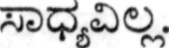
ಸಾಧ್ಯವಿಲ್ಲ.
